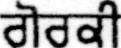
ਗੋਰਕੀ
